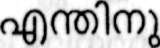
എന്തിനു
